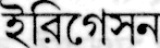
ইরিগেসন
